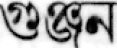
গুঞ্জন
